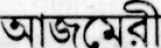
আজমেরী
